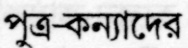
পুত্র-কন্যাদের
